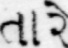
તારે
